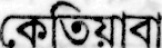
কেতিয়াবা
